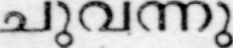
ചുവന്നു
